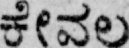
ಕೇವಲ
